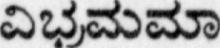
ವಿಭ್ರಮಮಾ
